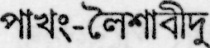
পাখং-লৈশাবীদু
